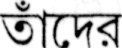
তাঁদের
